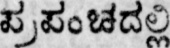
ಪ್ರಪಂಚದಲ್ಲಿ
